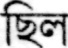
ছিল
